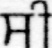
ਸੀ
